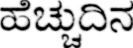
ಹೆಚ್ಚುದಿನ
